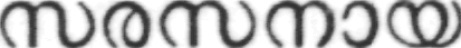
സരസനായ
